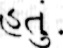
હતું.
